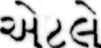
એટલે
